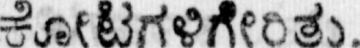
ಕೋಟಿಗಳಿಗೇರಿತು.
